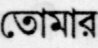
তোমার
